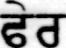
ਫੇਰ
